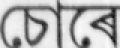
চোৰে
